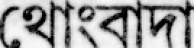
থোংবাদা
